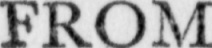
FROM
